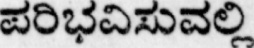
ಪರಿಭವಿಸುವಲ್ಲಿ
